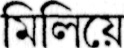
মিলিয়ে
